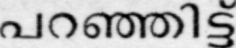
പറഞ്ഞിട്ട്
